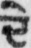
ਦੇ
